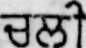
ਚਲੀ
